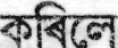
কৰিলে
